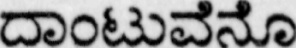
ದಾಂಟುವೆನೊ
